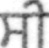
ਸੀ
